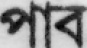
পাব
